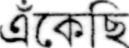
এঁকেছি
